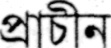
প্রাচীন
